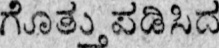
ಗೊತ್ತುಪಡಿಸಿದ
